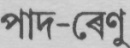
পাদ-ৰেণু
